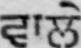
ਵਾਲੇ
